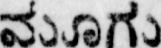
ಮೂಗು
